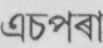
এচপৰা
